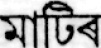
মাটিৰ
